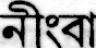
নীংবা
